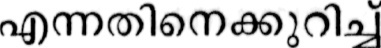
എന്നതിനെക്കുറിച്ച്
